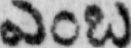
ಎಂಬ
